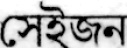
সেইজন
